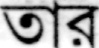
তার
